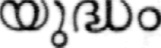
യുദ്ധം
